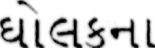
ઘોલકના
